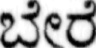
ಬೇರೆ
